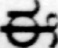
ಈ
